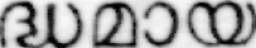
ദ്ധമായ
